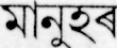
মানুহৰ
